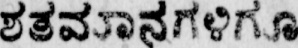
ಶತಮಾನಗಳಿಗೂ
